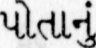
પોતાનું
